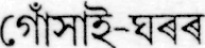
গোঁসাই-ঘৰৰ
